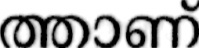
ത്താണ്
